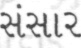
સંસાર
